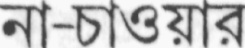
না-চাওয়ার
